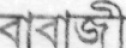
বাবাজী
